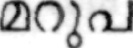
മറുപ
